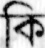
কি
